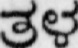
ತಳ
